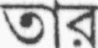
তার
